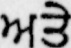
ਅਤੇ
